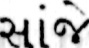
સાંજે
